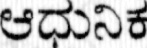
ಆಧುನಿಕ
